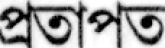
প্ৰতাপত
